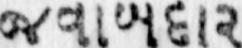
જવાબદાર
